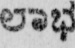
ಲಾಭ
